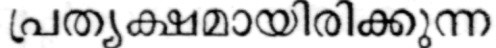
പ്രത്യക്ഷമായിരിക്കുന്ന
